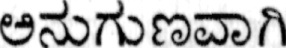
ಅನುಗುಣವಾಗಿ
